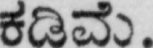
ಕಡಿಮೆ.
